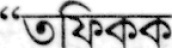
"তফিকক
